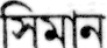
সিমান
